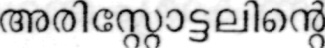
അരിസ്റ്റോട്ടലിന്റെ
